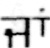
ਜਾਂ
